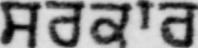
ਸਰਕਾਰ
